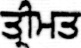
ਤ੍ਰੀਮਤ
